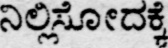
ನಿಲ್ಲಿಸೋದಕ್ಕೆ
